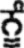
ਨੂੰ
